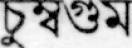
চুম্বগুম
